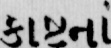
કાષ્ટનાં
